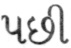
પછી
